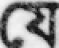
যে
